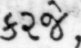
કરજે,
